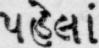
પહેલાં
